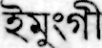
ইমুংগী
